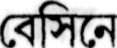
বেসিনে
